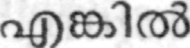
എങ്കില്‍
